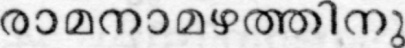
രാമനാമഴത്തിനു
